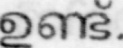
ഉണ്ട്.
